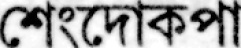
শেংদোকপা
